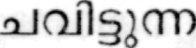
ചവിട്ടുന്ന
